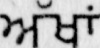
ਅੱਖਾਂ
